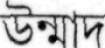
উন্মাদ
